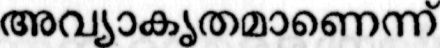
അവ്യാകൃതമാണെന്ന്
